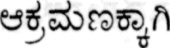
ಆಕ್ರಮಣಕ್ಕಾಗಿ
